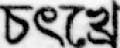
চৎখ্রে
